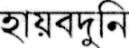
হায়বদুনি
